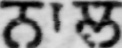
ਨਾਲ
